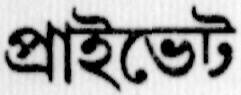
প্রাইভেট
